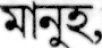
মানুহ,
